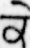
ਕੇ
